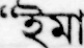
“ইমা
